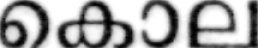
കൊല
